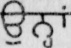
ਉਨ੍ਹਾਂ
